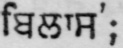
ਬਿਲਾਸ';
